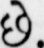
છે.
